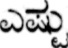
ಎಷ್ಟು
